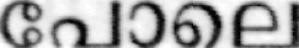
പോലെ
